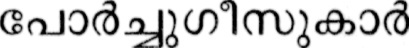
പോര്‍ച്ചുഗീസുകാര്‍
